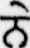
ਨੇ
